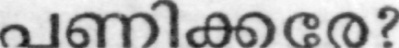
പണിക്കരേ?
